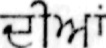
ਦੀਆਂ
